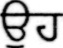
ਉਹ
